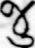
જુ
